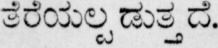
ತೆರೆಯಲ್ಪಡುತ್ತದೆ.
